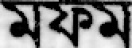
মফম
